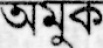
অমুক
